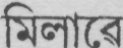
মিলাৱে
